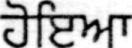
ਹੋਇਆ
